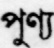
পুণ্য
